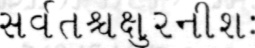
સર્વતશ્વક્ષુરનીશઃ
